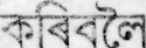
কৰিবলৈ
